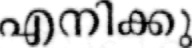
എനിക്കു
